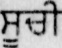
ਸੂਚੀ
